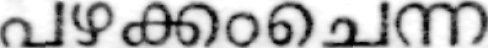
പഴക്കംചെന്ന
